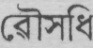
ৱৌসধি
